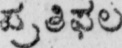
ಪ್ರತಿಫಲ
